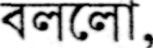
বললো,
